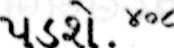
પડશે.૪૦૮
